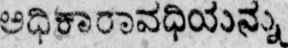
ಅಧಿಕಾರಾವಧಿಯನ್ನು
